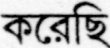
করেছি
